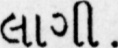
લાગી.
